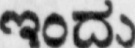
ಇಂದು
